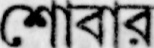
শোবার
